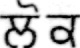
ਲੋਕ
